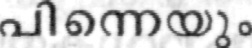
പിന്നെയും
